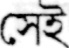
সেই
